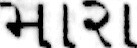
મારા
